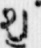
શું
